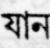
যান
